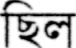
ছিল
